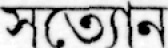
সত্যোন
